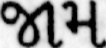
જામ
